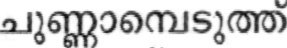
ചുണ്ണാമ്പെടുത്ത്
